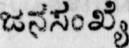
ಜನಸಂಖ್ಯೆ
